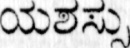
ಯಶಸ್ಸು
